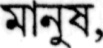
মানুষ,
